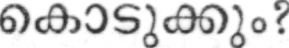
കൊടുക്കും?
